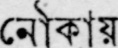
নৌকায়
